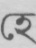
হে
